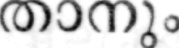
താനും
